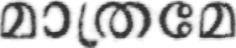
മാത്രമേ
